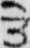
ਤੇ
